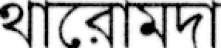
থারোমদা
